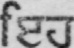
ਇਹ
